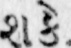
શકે.
